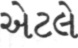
એટલે
